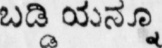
ಬಡ್ಡಿಯನ್ನೂ
